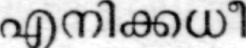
എനിക്കധീ
